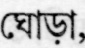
ঘোড়া,
